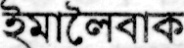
ইমালৈবাক
